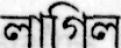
লাগিল
